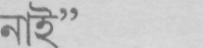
নাই"
